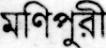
মণিপুরী
